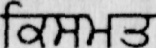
ਕਿਸਮਤ
